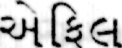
એફિલ
